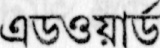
এডওয়ার্ড
